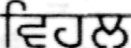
ਵਿਹਲ
